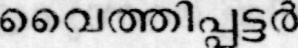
വൈത്തിപ്പട്ടര്‍
